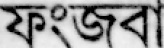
ফংজবা
